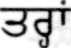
ਤਰ੍ਹਾਂ
